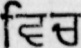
ਵਿਚ
